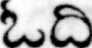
ಓದಿ
